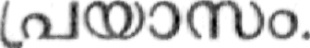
പ്രയാസം.
